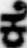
ಕೆ
